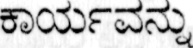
ಕಾರ್ಯವನ್ನು
